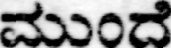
ಮುಂದೆ
